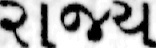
રાજ્ય
